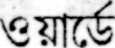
ওয়ার্ডে
